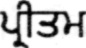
ਪ੍ਰੀਤਮ
